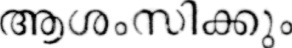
ആശംസിക്കും
